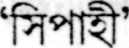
‘সিপাহী’
